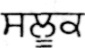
ਸਲੂਕ
